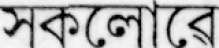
সকলোৱে
